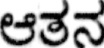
ಆತನ
